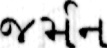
જર્મન
